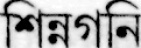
শিন্নগনি
